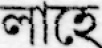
লাহে
